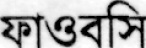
ফাওবসি
